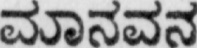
ಮಾನವನ
